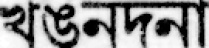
খঙনদনা
